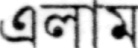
এলাম
